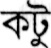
কটু
